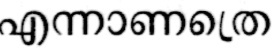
എന്നാണത്രെ
